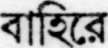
বাহিরে
